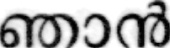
ഞാന്‍
